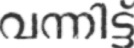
വന്നിട്ട്
